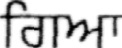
ਗਿਆ
